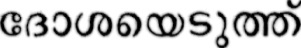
ദോശയെടുത്ത്
